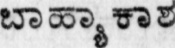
ಬಾಹ್ಯಾಕಾಶ
